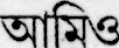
আমিও
